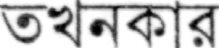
তখনকার
